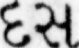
દસ
